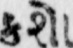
કશો
